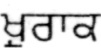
ਖ਼ੁਰਾਕ
